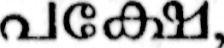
പക്ഷേ,
